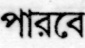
পারবে
